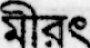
মীরৎ
